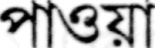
পাওয়া
